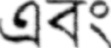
এবং
